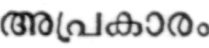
അപ്രകാരം
